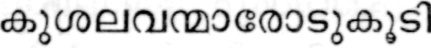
കുശലവന്മാരോടുകൂടി
